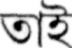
তাই
